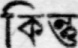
কিন্তু
